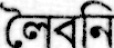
লৈবনি
